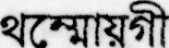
থম্মোয়গী
